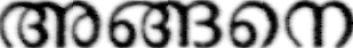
അങ്ങനെ
